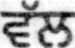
ਵੱਲ
